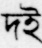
দই
